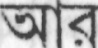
আর
